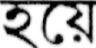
হয়ে
